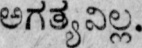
ಅಗತ್ಯವಿಲ್ಲ.
